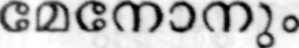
മേനോനും
